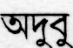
অদুবু
